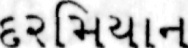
દરમિયાન
